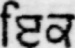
ਇਕ
